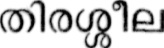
തിരശ്ശീല
